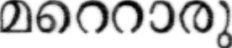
മറെറാരു
